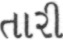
તારી
